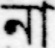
না
